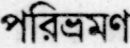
পরিভ্রমণ
